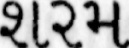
શરમ
